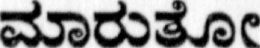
ಮಾರುತೋ
